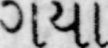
ગયા
